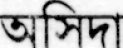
অসিদা
